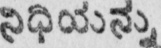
ನಿಧಿಯನ್ನು
